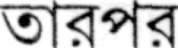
তারপর
